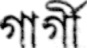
গার্গী
